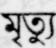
মৃত্যু
